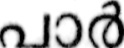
പാര്‍
